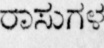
ರಾಸುಗಳ
